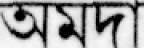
অমদা
